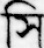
সি
